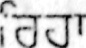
ਰਿਹਾ
